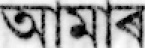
আমাৰ
